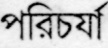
পরিচর্যা
